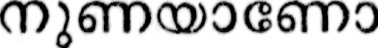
നുണയാണോ
